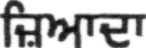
ਜ਼ਿਆਦਾ
